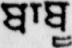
ਬਾਬੂ
